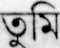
তুমি
